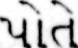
પોતે
